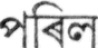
পৰিল
